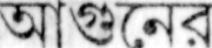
আগুনের
